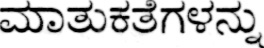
ಮಾತುಕತೆಗಳನ್ನು
